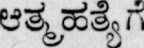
ಆತ್ಮಹತ್ಯೆಗೆ
